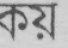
কয়
